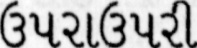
ઉપરાઉપરી
